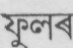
ফুলৰ
